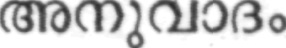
അനുവാദം
